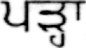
ਪੜ੍ਹਾ
